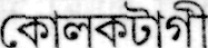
কোলকটাগী
